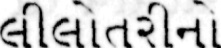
લીલોતરીનો
